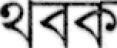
থবক
